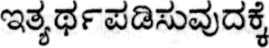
ಇತ್ಯರ್ಥಪಡಿಸುವುದಕ್ಕೆ
